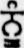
ਨੂੰ
